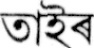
তাইৰ
